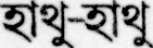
হাথু-হাথু
